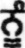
ਨੂੰ
